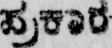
ಪ್ರಕಾರ
